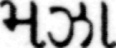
મઝા
